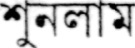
শুনলাম
